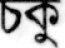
চকু
